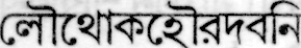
লৌথোকহৌরদবনি
